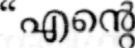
“എന്റെ
